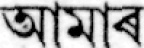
আমাৰ
